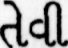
તેવી
